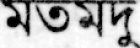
মতমদু
